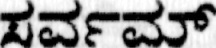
ಸರ್ವಮ್
